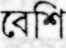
বেশি
